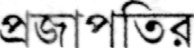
প্রজাপতির
